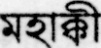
মহাক্কী
